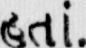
હતાં.
